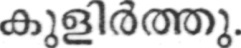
കുളിര്‍ത്തു.
